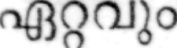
ഏറ്റവും
